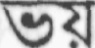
ভয়
